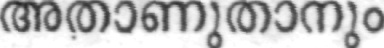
അതാണുതാനും
